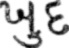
ખુદ
